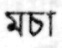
মচা
